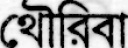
থৌরিবা
